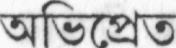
অভিপ্রেত
